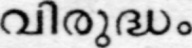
വിരുദ്ധം
